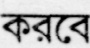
করবে
